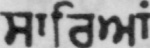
ਸਾਰਿਆਂ
